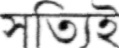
সত্যিই
